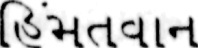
હિંમતવાન
